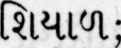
શિયાળ;
